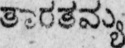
ತಾರತಮ್ಯ
